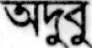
অদুবু
